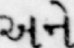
અને
